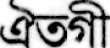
ঐতগী
